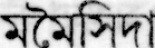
মমৈসিদা
